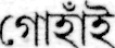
গোহাঁই
